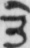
ਤੇ
